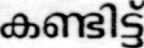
കണ്ടിട്ട്
